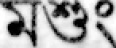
মশুং
